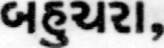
બહુચરા,
